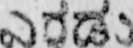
ಎರಡು
